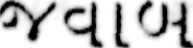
જવાબ
